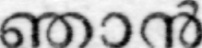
ഞാന്‍
